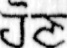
ਹੋਣ
